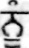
ਨੂੰ
